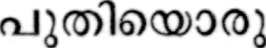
പുതിയൊരു
